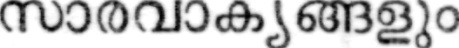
സാരവാക്യങ്ങളും
